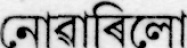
নোৱাৰিলো
